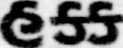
હક્ક
